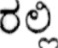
ರಲ್ಲಿ
